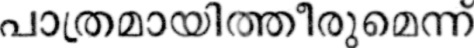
പാത്രമായിത്തീരുമെന്ന്
